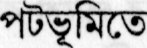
পটভূমিতে
